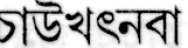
চাউখৎনবা
